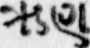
ઋણ
